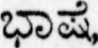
ಭಾಷೆ,
